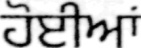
ਹੋਈਆਂ
